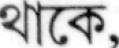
থাকে,
